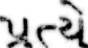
પ્રત્યે
